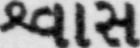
શ્વાસ
